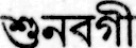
শুনবগী
